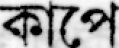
কাপে
